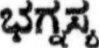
ಭಗ್ನಸ್ಯ
